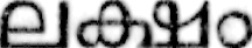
ലക്ഷം
